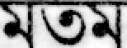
মতম
